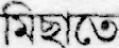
মিছাতে
